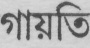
গায়তি
